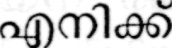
എനിക്ക്
